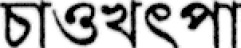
চাওখৎপা
